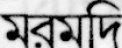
মরমদি
